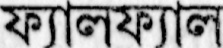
ফ্যালফ্যাল
